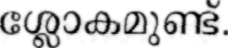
ശ്ലോകമുണ്ട്.
